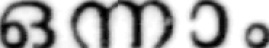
ഒന്നാം
